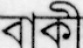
বাকী
